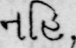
નહિ,
